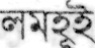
লমহূই
